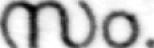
സം.
